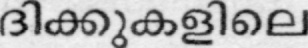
ദിക്കുകളിലെ
